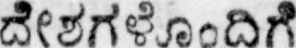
ದೇಶಗಳೊಂದಿಗೆ
